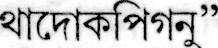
থাদোকপিগনু”
